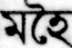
মহৈ
